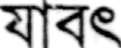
যাবৎ
